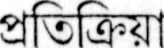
প্রতিক্রিয়া
